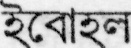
ইবোহল
